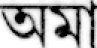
অমা
